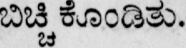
ಬಿಚ್ಚಿಕೊಂಡಿತು.
